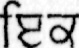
ਇਕ
